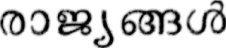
രാജ്യങ്ങള്‍
